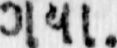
ગયા.
